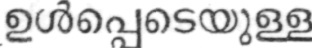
ഉള്‍പ്പെടെയുള്ള
